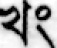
খং
